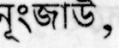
নূংজাউ,
